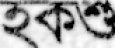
হকশু
